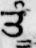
ਤੂੰ
